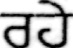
ਰਹੇ
